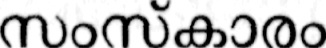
സംസ്കാരം
